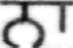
ਨਾ
